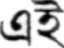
এই
